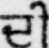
ਦੀ
